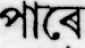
পাৰে
